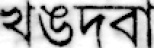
খঙদবা
